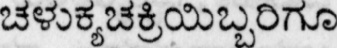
ಚಳುಕ್ಯಚಕ್ರಿಯಿಬ್ಬರಿಗೂ
